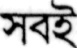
সবই
